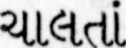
ચાલતાં
